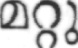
മറ്റു
